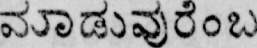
ಮಾಡುವುರೆಂಬ
